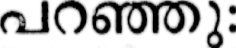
പറഞ്ഞു:
